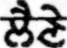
ਲੈਣੇ
